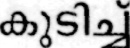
കുടിച്ച്
